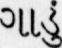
ગાડું
